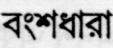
বংশধারা
